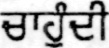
ਚਾਹੁੰਦੀ
